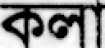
কলা
